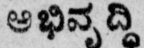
ಅಭಿವೃದ್ಧಿ
